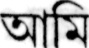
আমি
